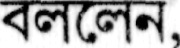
বললেন,
